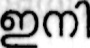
ഇനി
